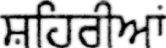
ਸ਼ਹਿਰੀਆਂ
